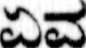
ಏವ
